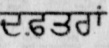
ਦਫ਼ਤਰਾਂ
